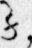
કે,
